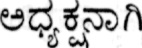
ಅಧ್ಯಕ್ಷನಾಗಿ
